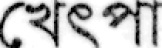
খেৎপা
